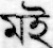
মই
